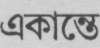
একান্তে
